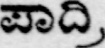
ಪಾದ್ರಿ
